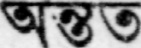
অন্তত
